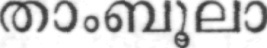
താംബൂലാ
